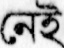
নেই
